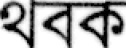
থবক
